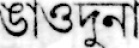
ঙাওদুনা
